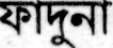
ফাদুনা
